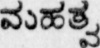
ಮಹತ್ವ
